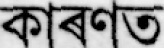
কাৰণত
